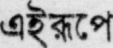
এইরূপে
